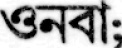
ওনবা;
